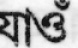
যাওঁ
